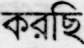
করছি
